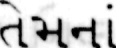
તેમનાં
